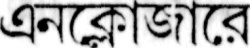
এনক্লোজারে
